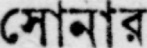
সোনার
